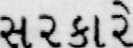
સરકારે
